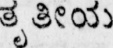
ತೃತೀಯ
